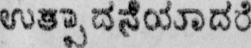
ಉತ್ಪಾದನೆಯಾದರೆ
